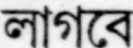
লাগবে
